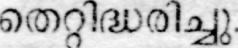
തെറ്റിദ്ധരിച്ചു.
